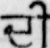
ਦੀ
